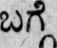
ಬಗ್ಗೆ
